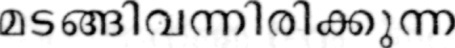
മടങ്ങിവന്നിരിക്കുന്ന
